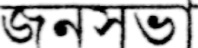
জনসভা
